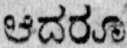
ಆದರೂ
